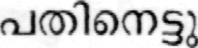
പതിനെട്ടു
